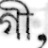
গী,
